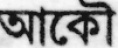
আকৌ
